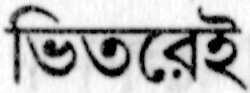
ভিতরেই
